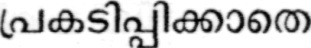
പ്രകടിപ്പിക്കാതെ
